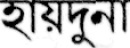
হায়দুনা
